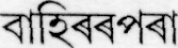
বাহিৰৰপৰা
